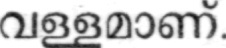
വള്ളമാണ്.
